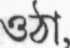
ওঠা,
